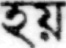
হয়
